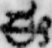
ಈ
